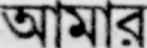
আমার
